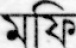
মফি
